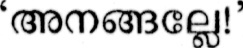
‘അനങ്ങല്ലേ!’
